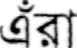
এঁরা
